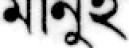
মানুহ
